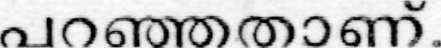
പറഞ്ഞതാണ്.
